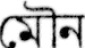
মৌন
